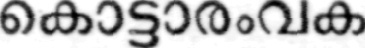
കൊട്ടാരംവക
